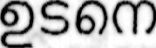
ഉടനെ
